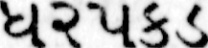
ધરપકડ
